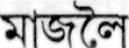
মাজলৈ
